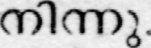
നിന്നു.
